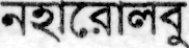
নহারোলবু
